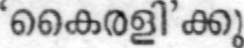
'കൈരളി'ക്കു
